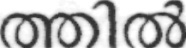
ത്തില്‍
